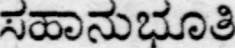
ಸಹಾನುಭೂತಿ
